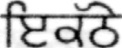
ਇਕੱਠੇ
